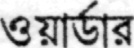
ওয়ার্ডার
